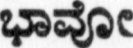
ಭಾವೋ
